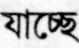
যাচ্ছে
